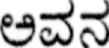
ಅವನ
